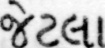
જેટલા
